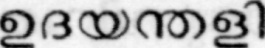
ഉദയന്തളി
